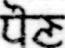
ਧੌਣ
